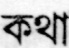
কথা
